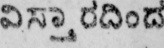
ವಿಸ್ತಾರದಿಂದ
